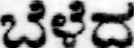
ಬೆಳೆದ
